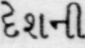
દેશની
